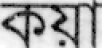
কয়া
